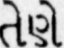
તેણે
